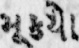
મૂક્યો
